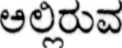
ಅಲ್ಲಿರುವ
